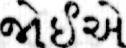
જોઈએ
